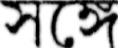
সঙ্গে
